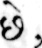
છે,
